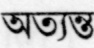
অত্যন্ত
